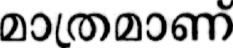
മാത്രമാണ്
